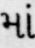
માં
